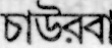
চাউরবা
